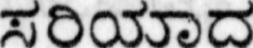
ಸರಿಯಾದ
